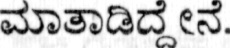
ಮಾತಾಡಿದ್ದೇನೆ.
